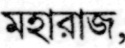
মহারাজ,
